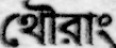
থৌরাং
